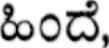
ಹಿಂದೆ,
